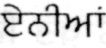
ਏਨੀਆਂ
